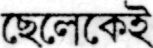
ছেলেকেই
